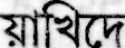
য়াখিদে
